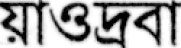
য়াওদ্রবা
